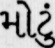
મોટું
